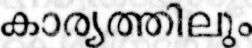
കാര്യത്തിലും
